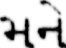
મને
